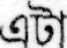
এটা
